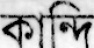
কান্দি
